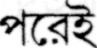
পরেই
